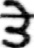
ਤੇ
